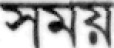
সময়
